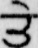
ਤੇ
